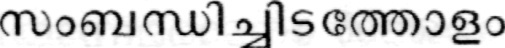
സംബന്ധിച്ചിടത്തോളം
